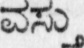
ವಸ್ತು
